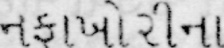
નફાખોરીના
